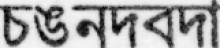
চঙনদবদা
